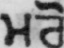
ਮਰੋ
